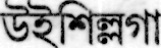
উইশিল্লগা
